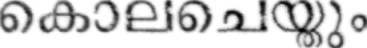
കൊലചെയ്തും
